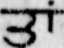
ਤਾਂ
